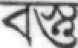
বস্তু
